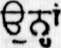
ਉਨ੍ਹਾਂ
